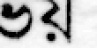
ভয়
